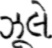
ઝુલે
